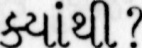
ક્યાંથી?
